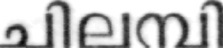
ചിലമ്പി
